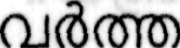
വര്‍ത്ത
